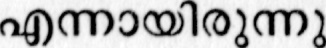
എന്നായിരുന്നു
